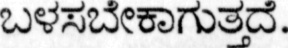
ಬಳಸಬೇಕಾಗುತ್ತದೆ.
